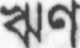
ঋণ
